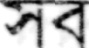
সব
